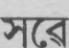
সৱে
